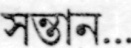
সন্তান...
